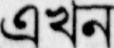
এখন
